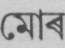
মোৰ
